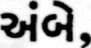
અંબે,
